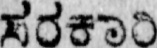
ಸರಕಾರಿ
